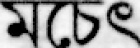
মচেৎ
